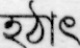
হঠাৎ
